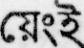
য়েংই
